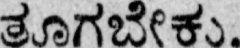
ತೂಗಬೇಕು.
